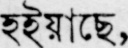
হইয়াছে,
